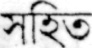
সহিত
